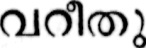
വറീതു
